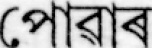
পোৱাৰ
